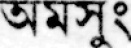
অমসুং
